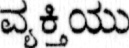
ವ್ಯಕ್ತಿಯು
